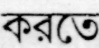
করতে
